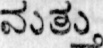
ಮತ್ತು
